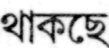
থাকছে
